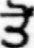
ਤੋਂ
